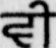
ਵੀ
